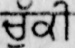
ਚੁੱਕੀ
